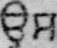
ਉਸ
